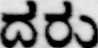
ದರು
